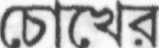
চোখের
